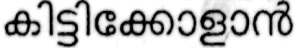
കിട്ടിക്കോളാന്‍
